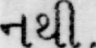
નથી.
